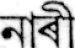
নাৰী
